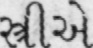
સ્ત્રીએ
